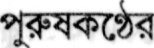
পুরুষকণ্ঠের
